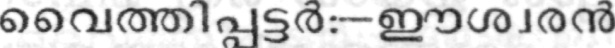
വൈത്തിപ്പട്ടര്‍:-ഈശ്വരന്‍
